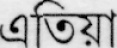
এতিয়া
